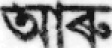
আৰু
